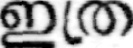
ഇത്ര
